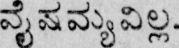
ವೈಷಮ್ಯವಿಲ್ಲ.
